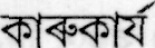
কাৰুকার্য
